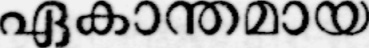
ഏകാന്തമായ
